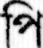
পি
